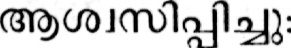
ആശ്വസിപ്പിച്ചു:
